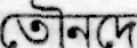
তৌনদে
